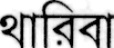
থারিবা
